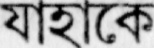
যাহাকে
